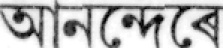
আনন্দেৰে
